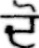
ਦੋ
